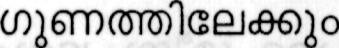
ഗുണത്തിലേക്കും
